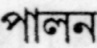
পালন
